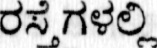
ರಸ್ತೆಗಳಲ್ಲಿ
